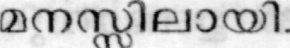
മനസ്സിലായി.
